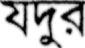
যদুর
